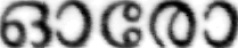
ഓരോ
